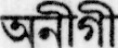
অনীগী
